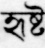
হৃষ্ট
